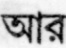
আর
